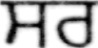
ਸਰ
